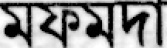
মফমদা
